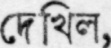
দেখিল,
